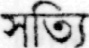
সত্যি
